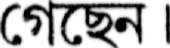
গেছেন।
